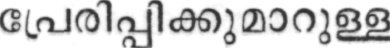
പ്രേരിപ്പിക്കുമാറുള്ള
